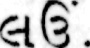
લઉં.
